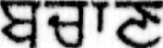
ਬਚਾਣ
